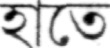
হাতে
